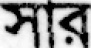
সার
